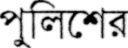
পুলিশের
